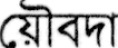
য়ৌবদা
